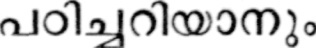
പഠിച്ചറിയാനും
